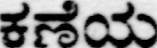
ಕಣೆಯ
